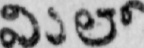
ಮಿಲ್
